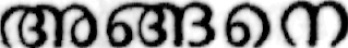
അങ്ങനെ
